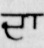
ਦਾ
